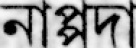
নাপ্পদা
